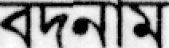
বদনাম
